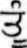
ਤੂੰ
